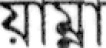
য়াম্না
